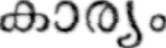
കാര്യം
